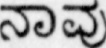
ನಾವು
